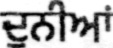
ਦੁਨੀਆਂ
